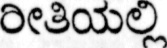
ರೀತಿಯಲ್ಲಿ
